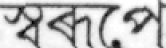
স্বৰূপে
